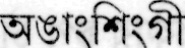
অঙাংশিংগী
